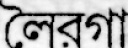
লৈরগা
